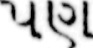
પણ
